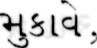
મુકાવે,
